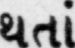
થતાં
